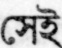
সেই
